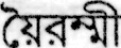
য়ৈরম্মী
